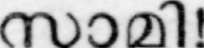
സാമി!
